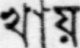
খায়
